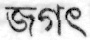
জগৎ
